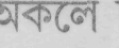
অকলে
